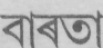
বাৰতা
